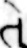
તે
